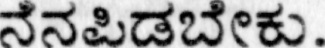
ನೆನಪಿಡಬೇಕು.
